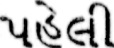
પહેલી
